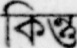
কিন্তু
